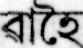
ৱাহৈ
